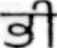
ਭੀ
